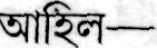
আহিল-
